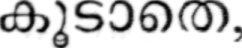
കൂടാതെ,
